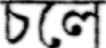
চলে
